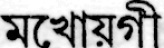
মখোয়গী
